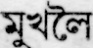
মুখলৈ
